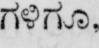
ಗಳಿಗೂ,
